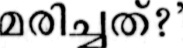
മരിച്ചത്?’
